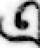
এ
